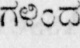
ಗಳಿಂದ
